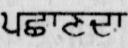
ਪਛਾਣਦਾ
